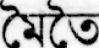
মৈতৈ
